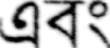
এবং
